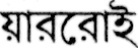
য়াররোই
